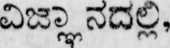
ವಿಜ್ಞಾನದಲ್ಲಿ,
